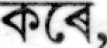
কৰে,
